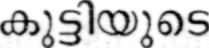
കുട്ടിയുടെ
